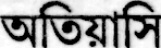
অতিয়াসি
